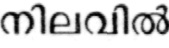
നിലവില്‍
